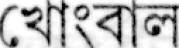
খোংবাল
